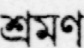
শ্রমণ
